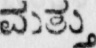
ಮತ್ತು
